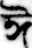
ঈ
